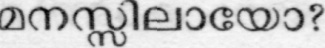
മനസ്സിലായോ?
